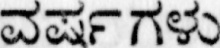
ವರ್ಷಗಳು
